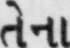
તેના
